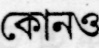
কোনও
